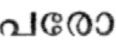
പരോ
